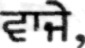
ਵਾਜੇ,
